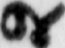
જ
